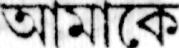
আমাকে
